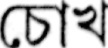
চোখ
